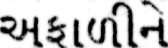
અફાળીને
